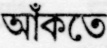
আঁকতে
